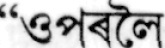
"ওপৰলৈ
